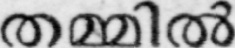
തമ്മില്‍
